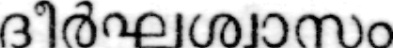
ദീര്‍ഘശ്വാസം
